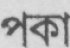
পকা
